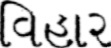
વિહાર
